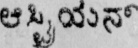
ಆಸ್ಟ್ರಿಯನ್
